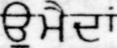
ਉਮੈਦਾਂ
